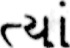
ત્યાં
